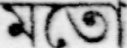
মতো
